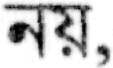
নয়,
